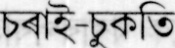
চৰাই-চুকতি
